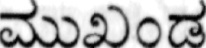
ಮುಖಂಡ
